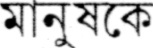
মানুষকে
